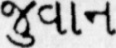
જુવાન
